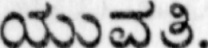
ಯುವತಿ.
